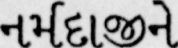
નર્મદાજીને
